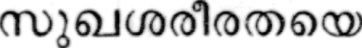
സുഖശരീരതയെ
